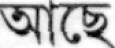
আছে
